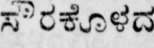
ಸೌರಕೊಳದ
